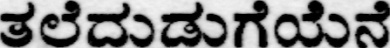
ತಲೆದುಡುಗೆಯೆನೆ
